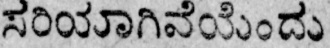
ಸರಿಯಾಗಿವೆಯೆಂದು
